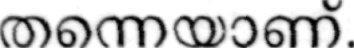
തന്നെയാണ്.
